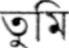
তুমি
